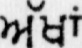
ਅੱਖਾਂ
